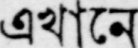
এখানে
